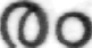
രം
